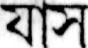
যাস
